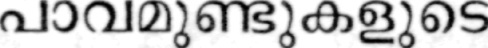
പാവമുണ്ടുകളുടെ
